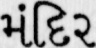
મંદિર
